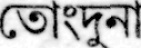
তোংদুনা
